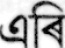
এৰি
